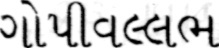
ગોપીવલ્લભ
